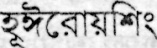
হূঈরোয়শিং
